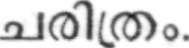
ചരിത്രം.
